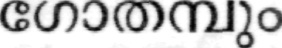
ഗോതമ്പും
